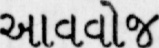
આવવોજ
